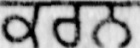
ਕਰਨ
